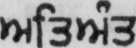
ਅਤਿਅੰਤ
